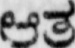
ಆತ
